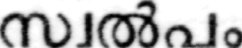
സ്വല്‍പം
